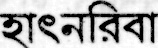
হাৎনরিবা
